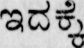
ಇದಕ್ಕೆ
